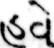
હવે
